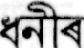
ধনীৰ
